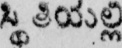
ಸ್ಥಿತಿಯಲ್ಲಿ
